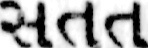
સતત
